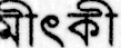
মীৎকী
